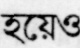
হয়েও
